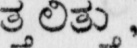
ತ್ತಲಿತ್ತು,
